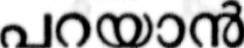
പറയാന്‍
